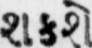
શકશે
